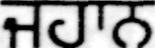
ਜਹਾਨ
